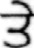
ਤੇ
